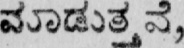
ಮಾಡುತ್ತವೆ,
